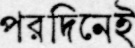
পরদিনেই
